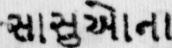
સાસુઓના
